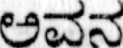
ಅವನ
